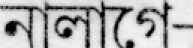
নালাগে-
